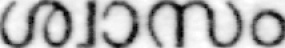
ശ്വാസം
